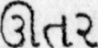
ઊતર
